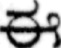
ಈ
